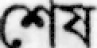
শেষ
